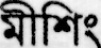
মীশিং
